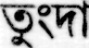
তুংদা
